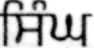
ਸਿੰਘ
